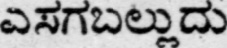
ಎಸಗಬಲ್ಲುದು
